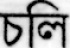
চলি
